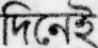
দিনেই
